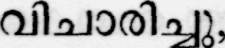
വിചാരിച്ചു,
